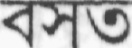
বসত
